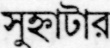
সুহ্নাটার
